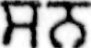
ਸਨ
